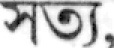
সত্য,
